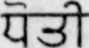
ਧੋਤੀ
